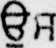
ਉਸ
